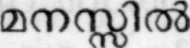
മനസ്സില്‍
